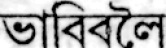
ভাবিবলৈ
